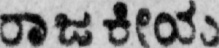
ರಾಜಕೀಯ
